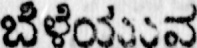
ಬೆಳೆಯುವ
